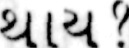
થાય?
